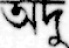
অদু
